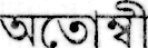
অতোম্বী
